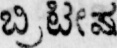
ಬ್ರಿಟೀಷ
